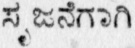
ಸೃಜನೆಗಾಗಿ
